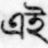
এই
